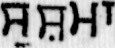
ਸੁਸ਼ਮਾ
